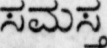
ಸಮಸ್ತ
